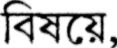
বিষয়ে,
